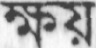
ক্ষয়
